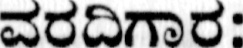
ವರದಿಗಾರ:
